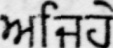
ਅਜਿਹੇ
